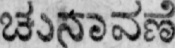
ಚುನಾವಣೆ
